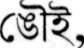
ঙৌই,
